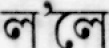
ল'লে
